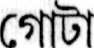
গোটা
